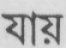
যায়
